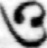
ও
